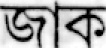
জাক
